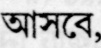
আসবে,
